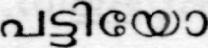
പട്ടിയോ
